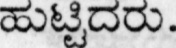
ಹುಟ್ಟಿದರು.
